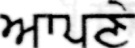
ਆਪਣੇ
